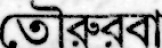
তৌরুরবা
